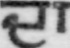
ਦਾ
